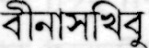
বীনাসখিবু
